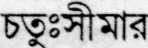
চতুঃসীমার
